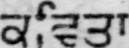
ਕਵਿਤਾ
